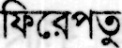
ফিরেপতু
